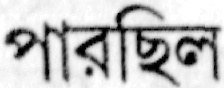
পারছিল
